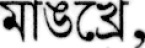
মাঙখ্রে,
